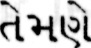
તેમણે
